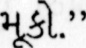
મૂકો."
